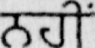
ਨਹੀਂ
